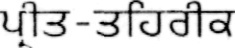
ਪ੍ਰੀਤ-ਤਹਿਰੀਕ
